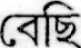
বেছি
